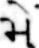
મેં
